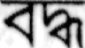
বদ্ধ
